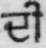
ਦੀ
